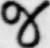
જ
